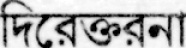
দিরেক্তরনা
